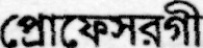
প্রোফেসরগী
